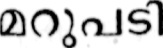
മറുപടി
